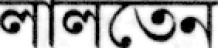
লালতেন
